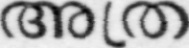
അത്ര
